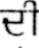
ਦੀ
